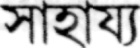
সাহায্য
